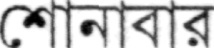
শোনাবার
